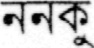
ননকু
